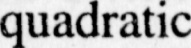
quadratic
